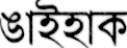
ঙাইহাক
